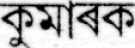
কুমাৰক
